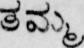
ತಮ್ಮ
